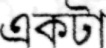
একটা
